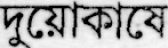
দুয়োকাষে
